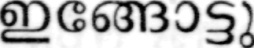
ഇങ്ങോട്ടു
